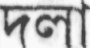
দলা
